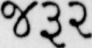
જરૂર
